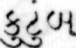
કુંટુબ
